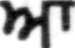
ਆ
